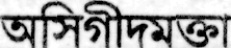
অসিগীদমক্তা
